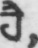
ਹੈ,
